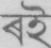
ৰই
